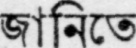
জানিতে
